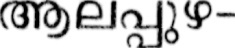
ആലപ്പുഴ-
